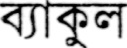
ব্যাকুল
